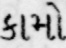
કામો
